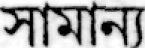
সামান্য
